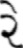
રે
